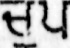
ਚੁਪ
